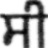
ਸੀ
